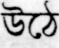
উঠে
